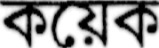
কয়েক
